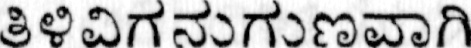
ತಿಳಿವಿಗನುಗುಣವಾಗಿ
